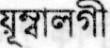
য়ূম্বালগী
